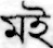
মই
